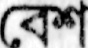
বেশ
